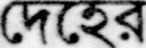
দেহের
